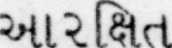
આરક્ષિત
